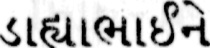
ડાહ્યાભાઈને
